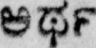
ಅರ್ಥ
